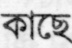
কাছে
